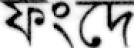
ফংদে
